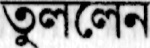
তুললেন
